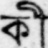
কী
